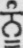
ਨੂੰ
